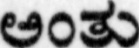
ಅಂತು
